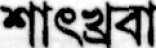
শাৎখ্রবা
